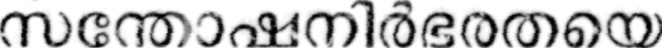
സന്തോഷനിര്‍ഭരതയെ
